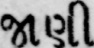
જાણી
